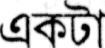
একটা
